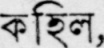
কহিল,
